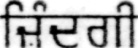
ਜ਼ਿੰਦਗੀ
